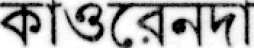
কাওরেনদা
